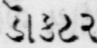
ડૉક્ટર
